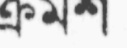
ক্রমশ
